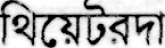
থিয়েটরদা
